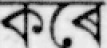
কৰে
